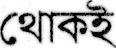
থোকই
